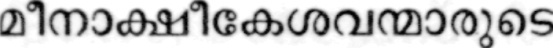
മീനാക്ഷീകേശവന്മാരുടെ
